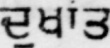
ਦੁਖਾਂਤ
